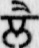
ਲੈ
